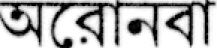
অরোনবা
